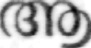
ആ
